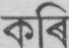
কৰি
